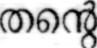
തന്റെ
